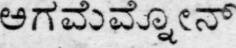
ಅಗಮೆಮ್ನೋನ್
